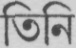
তিনি
